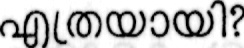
എത്രയായി?
